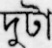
দুটা
